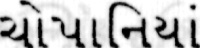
ચોપાનિયાં
